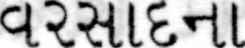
વરસાદના
